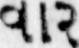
વાર
